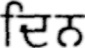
ਦਿਨ
